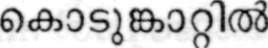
കൊടുങ്കാറ്റില്‍
